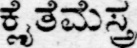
ಕ್ಲೈತೆಮೆಸ್ತ್ರ
